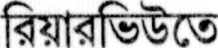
রিয়ারভিউতে
